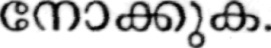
നോക്കുക.
